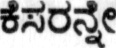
ಕೆಸರನ್ನೇ
